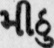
મીઠુ
